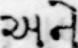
અને
